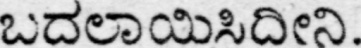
ಬದಲಾಯಿಸಿದೀನಿ.
